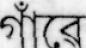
গাঁৱে
